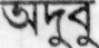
অদুবু
